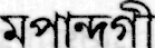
মপান্দগী
